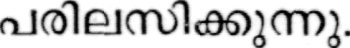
പരിലസിക്കുന്നു.
